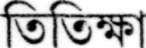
তিতিক্ষা
